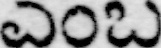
ಎಂಬ
